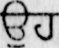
ਉਹ
